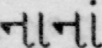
નાનાં
